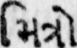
મિત્રો
